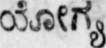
ಯೋಗ್ಯ
